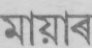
মায়াৰ
